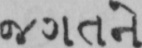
જગતને
